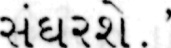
સંઘરશે.'
